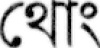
থোং
